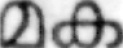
മക
